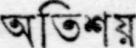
অতিশয়
